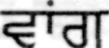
ਵਾਂਗ
